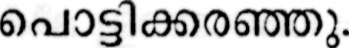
പൊട്ടിക്കരഞ്ഞു.
